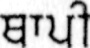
ਥਾਪੀ
